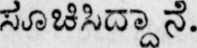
ಸೂಚಿಸಿದ್ದಾನೆ.
